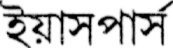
ইয়াসপার্স
